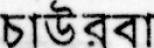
চাউরবা
